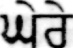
ਘੇਰੇ
